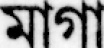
মাগা
